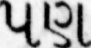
પણ
